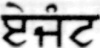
ਏਜੰਟ
